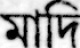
মাদি
